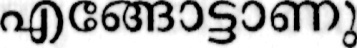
എങ്ങോട്ടാണു
